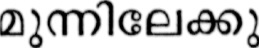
മുന്നിലേക്കു
